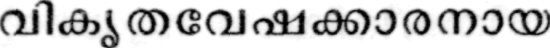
വികൃതവേഷക്കാരനായ
